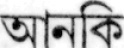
আনকি
